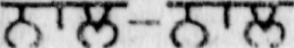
ਨਾਲ-ਨਾਲ
